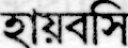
হায়বসি
